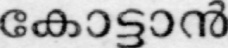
കോട്ടാന്‍
